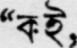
‘‘কই,
